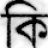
কি
